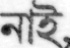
নাই,
